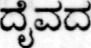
ದೈವದ
